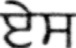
ਏਸ
